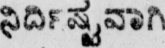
ನಿರ್ದಿಷ್ಟವಾಗಿ
